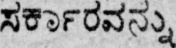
ಸರ್ಕಾರವನ್ನು
